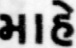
માહે
